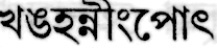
খঙহন্নীপোৎ
